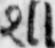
શી
